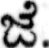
ಜೆ.
